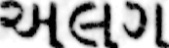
અલગ
